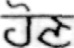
ਹੋਣ
